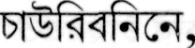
চাউরিবনিনে,
